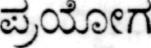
ಪ್ರಯೋಗ
